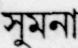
সুমনা
